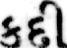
કદી
